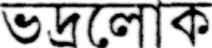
ভদ্রলোক
